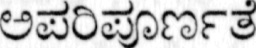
ಅಪರಿಪೂರ್ಣತೆ
